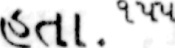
હતા.૧૫૫
